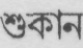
শুকান
